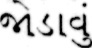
જોડાવું
